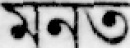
মনত
